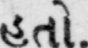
હતો.
